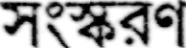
সংস্করণ
